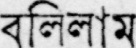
বলিলাম
